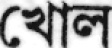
খোল
